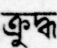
ক্রুদ্ধ
